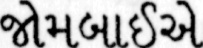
જોમબાઈએ
